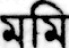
মমি
